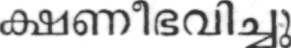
ക്ഷണീഭവിച്ചു
